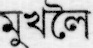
মুখলৈ
